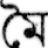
মৈ
